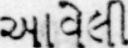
આવેલી
